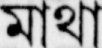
মাথা
